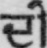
ਦੀ
